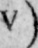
v)
